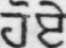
ਹੋਏ
